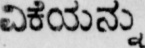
ವಿಕೆಯನ್ನು
